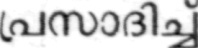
പ്രസാദിച്ച്
